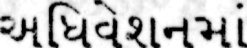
અધિવેશનમાં
